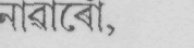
নাৱাৰো,
